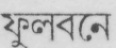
ফুলবনে
